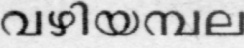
വഴിയമ്പല
